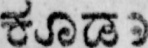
ಕೂಡಾ
